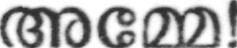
അമ്മേ!
